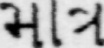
માત્ર
